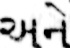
અને
